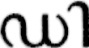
ഡി
